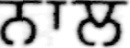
ਨਾਲ
